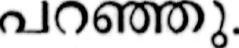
പറഞ്ഞു.
